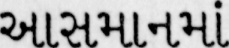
આસમાનમાં
